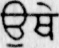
ਉਥੇ
